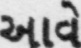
આવે
